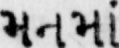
મનમાં
